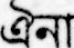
ঐনা
